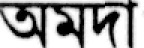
অমদা
